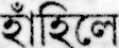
হাঁহিলে
